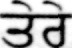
ਤੇਰੇ
